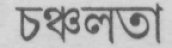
চঞ্চলতা
